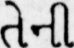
તેની
